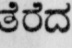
ತೆರೆದ
